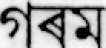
গৰম
